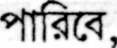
পারিবে,
